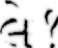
લે?
